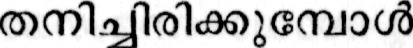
തനിച്ചിരിക്കുമ്പോള്‍
